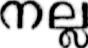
നല്ല
